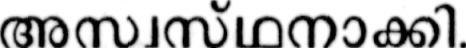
അസ്വസ്ഥനാക്കി.
